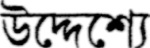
উদ্দেশ্যে
